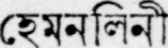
হেমনলিনী
